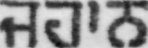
ਜਹਾਨ
